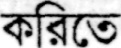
করিতে
